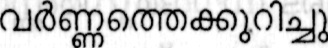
വര്‍ണ്ണത്തെക്കുറിച്ചു
